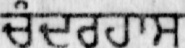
ਚੰਦਰਹਾਸ
